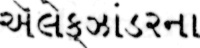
ઍલેક્ઝાંડરના
